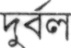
দুর্বল
